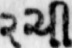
રચી
